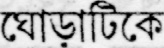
ঘোড়াটিকে
